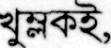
খুম্লকই,
